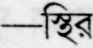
–স্থির
